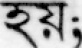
হয়;
